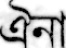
ঐনা
